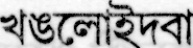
খঙলোইদবা
